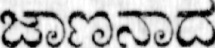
ಜಾಣನಾದ
